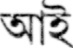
আই
